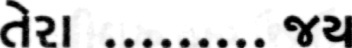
તેરા.......જય
